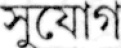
সুযোগ
